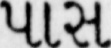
પાસ
